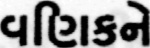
વણિકને
